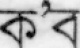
ক'ব
